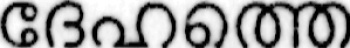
ദേഹത്തെ
